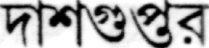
দাশগুপ্তর
